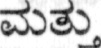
ಮತ್ತು
